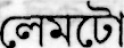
লেমটো
